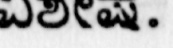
ವಿಶೇಷ.
